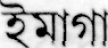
ইমাগা
